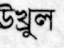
ঊখ্রুল
